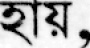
হায়,
